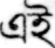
এই
